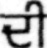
ਦੀ
